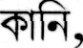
কানি,
